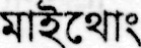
মাইথোং
